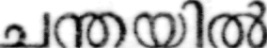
ചന്തയില്‍
